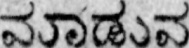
ಮಾಡುವ
